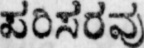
ಪರಿಸರವು
